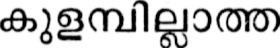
കുളമ്പില്ലാത്ത
